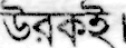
উরকই।
